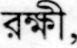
রক্ষী,
